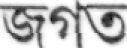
জগত
